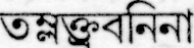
তম্লক্ত্রবনিনা
